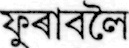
ফুৰাবলৈ
